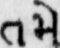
તમે
